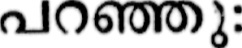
പറഞ്ഞു:
